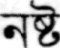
নষ্ট
